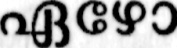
ഏഴോ
